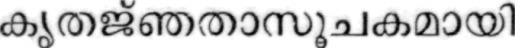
കൃതജ്ഞതാസൂചകമായി
